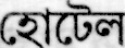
হোটেল
